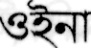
ওইনা
